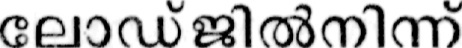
ലോഡ്ജില്‍നിന്ന്
